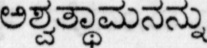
ಅಶ್ವತ್ಥಾಮನನ್ನು
